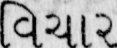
વિચાર
